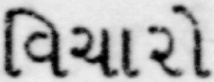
વિચારો
